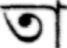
তা
